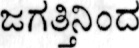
ಜಗತ್ತಿನಿಂದ
